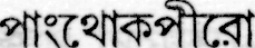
পাংথোকপীরো
